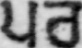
ਪਰ
